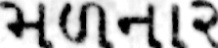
મળનાર
